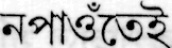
নপাওঁতেই
